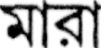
মারা
